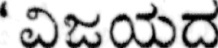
'ವಿಜಯದ
